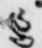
હું
